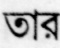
তার
